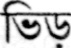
ভিড়
